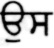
ਉਸ
